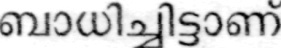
ബാധിച്ചിട്ടാണ്
